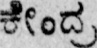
ಕೇಂದ್ರ
